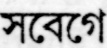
সবেগে
